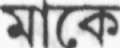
মাকে
